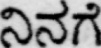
ನಿನಗೆ
